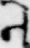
ને
